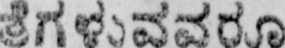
ತೆಗಳುವವರೂ
